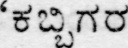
‘ಕಬ್ಬಿಗರ
